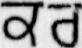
ਕਰ
